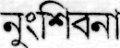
নুংশিবনা
